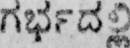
ಗರ್ಭದಲ್ಲಿ
